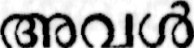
അവള്‍
